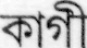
কাগী
